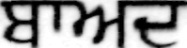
ਬਾਅਦ
